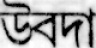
উবদা
